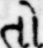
તો
